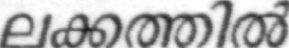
ലക്കത്തില്‍
